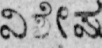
ವಿಶೇಷ
